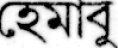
হেমাবু
